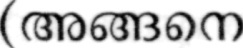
(അങ്ങനെ
